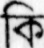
কি
